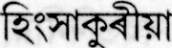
হিংসাকুৰীয়া
